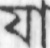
যা
